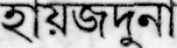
হায়জদুনা
